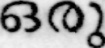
ഒരു
